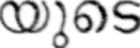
യുടെ
